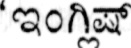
'ಇಂಗ್ಲಿಷ್
